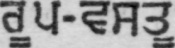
ਰੂਪ-ਵਸਤੂ
